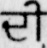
ਦੀ
